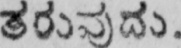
ತರುವುದು.
